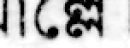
য়াল্লে
